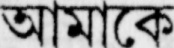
আমাকে
